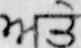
ਅਤੇ
